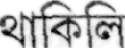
থাকিলি
